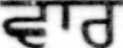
ਵਾਰ
